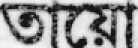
তায়ো
